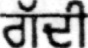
ਗੱਦੀ
